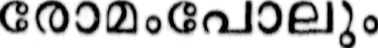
രോമംപോലും
